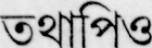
তথাপিও
